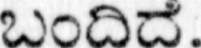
ಬಂದಿದೆ.
